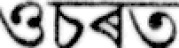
ওচৰত
